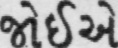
જોઈએ
